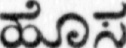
ಹೊಸ
